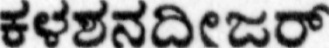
ಕಳಶನದೀಜರ್
